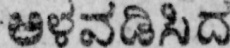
ಅಳವಡಿಸಿದ
